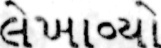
લેખાવ્યો
